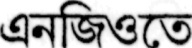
এনজিওতে
